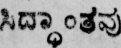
ಸಿದ್ಧಾ೦ತವು
